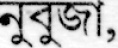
নুবুজা,
